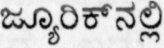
ಜ್ಯೂರಿಕ್‌ನಲ್ಲಿ
